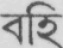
বহি
